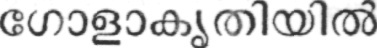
ഗോളാകൃതിയില്‍
